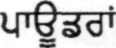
ਪਾਊਡਰਾਂ
